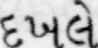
દખલે
